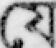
যে
